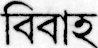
বিবাহ
